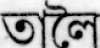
তালৈ
